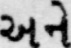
અને
